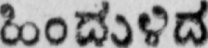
ಹಿಂದುಳಿದ
